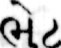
ભેટ
